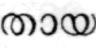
തായ
